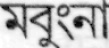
মবুংনা
